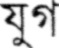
যুগ
